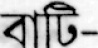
বাটি-
